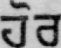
ਹੋਰ
